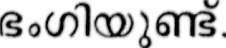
ഭംഗിയുണ്ട്.
